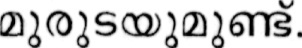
മുരുടയുമുണ്ട്.
